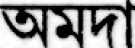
অমদা
